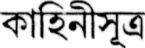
কাহিনীসূত্র
